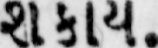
શકાય.
